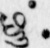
છું.
